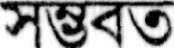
সম্ভবত
